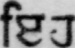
ਇਹ
